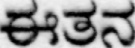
ಈತನ
